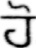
ਹੋ
